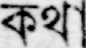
কথা
